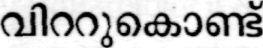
വിററുകൊണ്ട്
